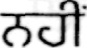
ਨਹੀਂ
